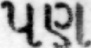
પણ
